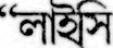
“লাইসি
